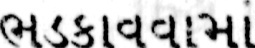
ભડકાવવામાં
